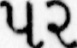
પર
